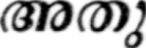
അതു
